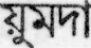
য়ুমদা
